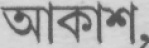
আকাশ,
